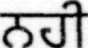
ਨਹੀ
